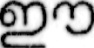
ഈ
